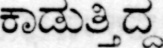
ಕಾಡುತ್ತಿದ್ದ
